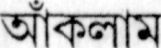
আঁকলাম
